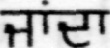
ਜਾਂਦਾ
